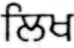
ਲਿਖ
